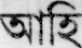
আহি
